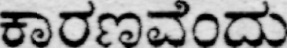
ಕಾರಣವೆಂದು
